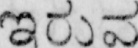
ಇರುವ
